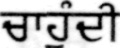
ਚਾਹੁੰਦੀ
